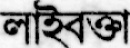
লাইবক্তা
